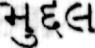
મુદ્દલ
